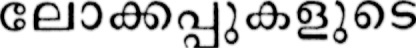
ലോക്കപ്പുകളുടെ
